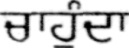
ਚਾਹੁੰਦਾ
